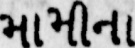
મામીના
